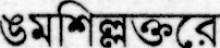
ঙমশিল্লক্তরে
